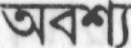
অবশ্য
